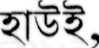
হাউই,
